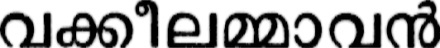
വക്കീലമ്മാവന്‍
